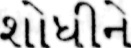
શોધીને
